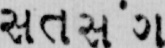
સતસંગ
